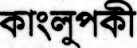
কাংলুপকী
